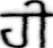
ਹੀ
